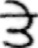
ਤੇ
